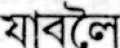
যাবলৈ
